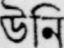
উনি
